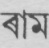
ৰাম
